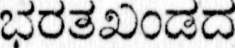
ಭರತಖಂಡದ
